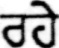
ਰਹੇ
